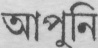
আপুনি
